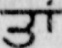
ਤਾਂ
